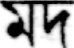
মদ
